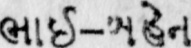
ભાઈ-બહેન
